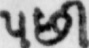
પછી
